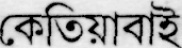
কেতিয়াবাই
